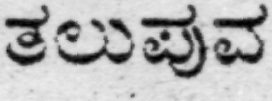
ಹೊಳೆಯುವೆ
